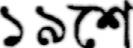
১৯শে
